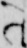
તે
